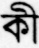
কী
